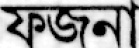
ফজনা
